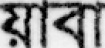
য়াবা
